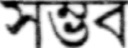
সম্ভব
